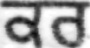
ਕਰ
